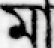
মা
